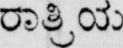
ರಾತ್ರಿಯ
